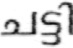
ചട്ടി
